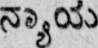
ನ್ಯಾಯ
